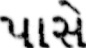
પાસે
